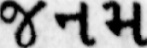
જનમ
